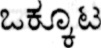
ಒಕ್ಕೂಟ
